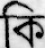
কি
